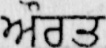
ਔਰਤ
